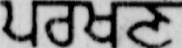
ਪਰਖਣ
